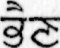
ਭੈਣ
